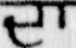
ਦਾ
